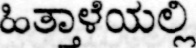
ಹಿತ್ತಾಳೆಯಲ್ಲಿ
